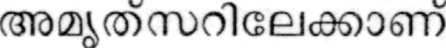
അമൃത്‌സറിലേക്കാണ്
